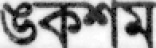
ঙমশম
